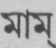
মাম্
